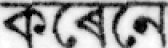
কৰেনে
